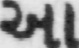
આ
